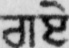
ਗਏ
